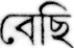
বেছি
